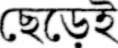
ছেড়েই
